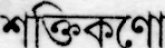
শক্তিকণো
